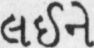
લઈને
